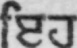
ਇਹ
